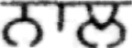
ਨਾਲ
